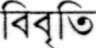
বিবৃতি
